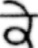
ਕੇ
